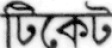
টিকেট
